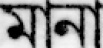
মানা
